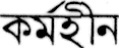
কৰ্মহীন
